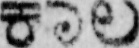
ಕಾಲ
